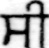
ਸੀ
